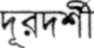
দূরদর্শী
